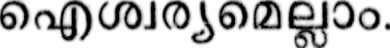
ഐശ്വര്യമെല്ലാം.
